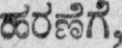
ಹರಣೆಗೆ,
